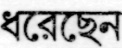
ধরেছেন
